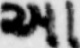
આ
